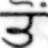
ਤੋਂ
